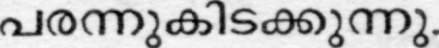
പരന്നുകിടക്കുന്നു.
